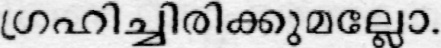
ഗ്രഹിച്ചിരിക്കുമല്ലോ.
